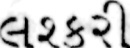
લશ્કરી
